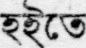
হইতে
